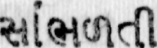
સાંભળતી
